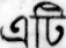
এটি
